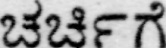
ಚರ್ಚಿಗೆ
